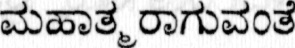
ಮಹಾತ್ಮರಾಗುವಂತೆ
